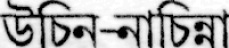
উচিন-নাচিন্না
